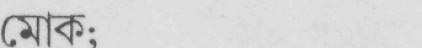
মোক;
